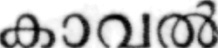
കാവല്‍
